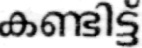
കണ്ടിട്ട്
